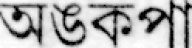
অঙকপা
